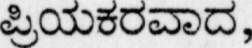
ಪ್ರಿಯಕರವಾದ,
